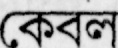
কেবল
